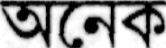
অনেক
